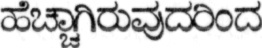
ಹೆಚ್ಚಾಗಿರುವುದರಿಂದ
